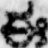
ಈ
